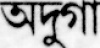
অদুগা
